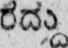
ರದ್ದು
